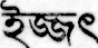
ইজ্জৎ
